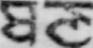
ਬਣ
